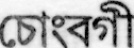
চোংবগী
